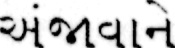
અંજાવાને
